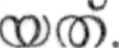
യത്.
